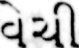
વેચી
